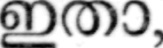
ഇതാ,
